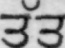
ਤੱਤ
